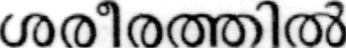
ശരീരത്തില്‍
